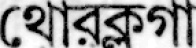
থোরক্লগা
